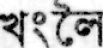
খংলৈ
